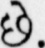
છે.
